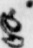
હું
